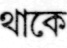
থাকে
